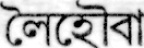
লৈহৌবা
